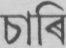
চাৰি
